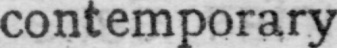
contempoary
